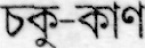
চকু-কাণ
